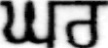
ਘਰ
